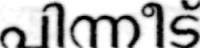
പിന്നീട്
